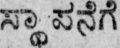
ಸ್ಥಾಪನೆಗೆ
